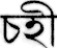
চহী
